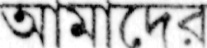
আমাদের
